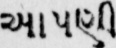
આપણી
